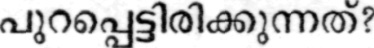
പുറപ്പെട്ടിരിക്കുന്നത്?
